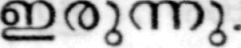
ഇരുന്നു.
